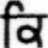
ਕਿ
